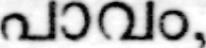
പാവം,
